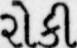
રોકી
